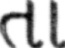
તા
